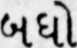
બધો
